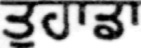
ਤੁਹਾਡਾ
